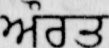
ਔਰਤ
